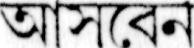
আসবেন
